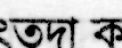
থম্বৌনা
